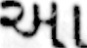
આ
